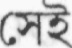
সেই
